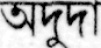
অদুদা
